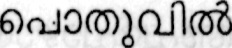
പൊതുവില്‍
